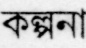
কল্পনা
